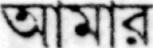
আমার
